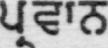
ਪ੍ਰਵਾਨ
